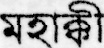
মহাক্কী
